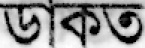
ডাকত
